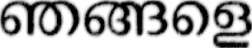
ഞങ്ങളെ
